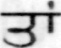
ਤਾਂ
